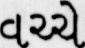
વચ્ચે
